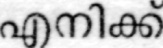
എനിക്ക്
